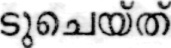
ടുചെയ്ത്
